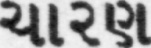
ચારણ
